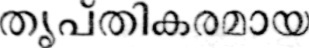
തൃപ്തികരമായ
